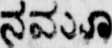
ನಮೂ
